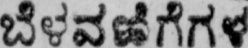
ಬೆಳವಣಿಗೆಗಳ
